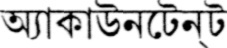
অ্যাকাউনটেন্ট
